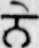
ਨੇ
